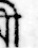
মী
